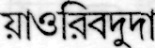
য়াওরিবদুদা
